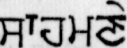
ਸਾਹਮਣੇ
